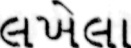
લખેલા
